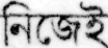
নিজেই
